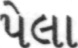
પેલા
